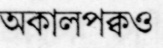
অকালপক্কও
